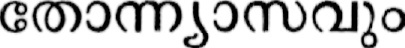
തോന്ന്യാസവും
